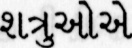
શત્રુઓએ
